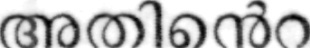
അതിന്റെ
